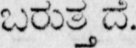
ಬರುತ್ತದೆ.
